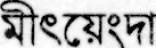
মীৎয়েংদা
